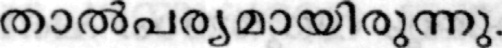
താല്‍പര്യമായിരുന്നു.
